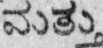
ಮತ್ತು
